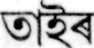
তাইৰ
